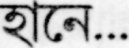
হানে...
